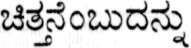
ಚಿತ್ತನೆಂಬುದನ್ನು
